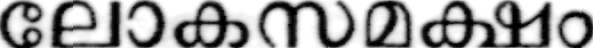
ലോകസമക്ഷം
